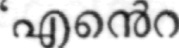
‘എന്റെ
